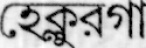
হেক্লুরগা
